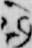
છે
